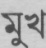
মুখ
